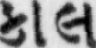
કાલ
